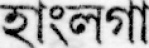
হাংলগা
